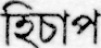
হিচাপ
